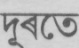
দূৰতে
